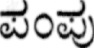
ಪಂಪು
